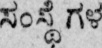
ಸಂಸ್ಥೆಗಳ
